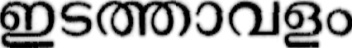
ഇടത്താവളം
